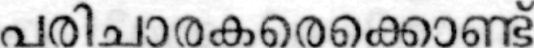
പരിചാരകരെക്കൊണ്ട്
